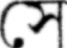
সে
